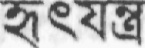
হৃত্যন্ত্র
